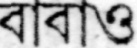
বাবাও
